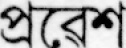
প্রৱেশ
